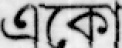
একো
